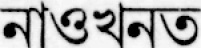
নাওখনত
